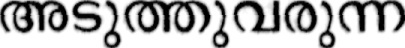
അടുത്തുവരുന്ന
